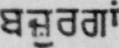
ਬਜ਼ੁਰਗਾਂ
